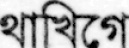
থাখিগে
